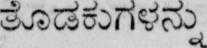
ತೊಡಕುಗಳನ್ನು
